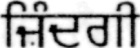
ਜ਼ਿੰਦਗੀ
